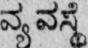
ವ್ಯವಸ್ಥೆ
